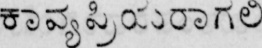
ಕಾವ್ಯಪ್ರಿಯರಾಗಲಿ
